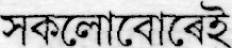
সকলোবোৰেই
